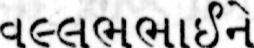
વલ્લભભાઈને
